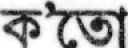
ক'তো
